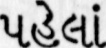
પહેલાં
